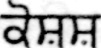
ਕੋਸ਼ਸ਼
